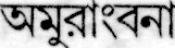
অমুরাংবনা
